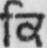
ਕਿ
